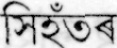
সিহঁতৰ
